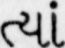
ત્યાં
